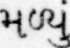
મળ્યું
